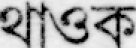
থাওক
